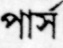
পার্স
